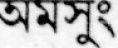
অমসুং
